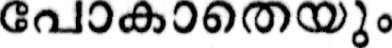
പോകാതെയും
